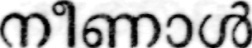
നീണാള്‍
